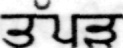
ਤੱਪੜ
